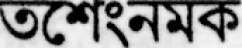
তশেংনমক
